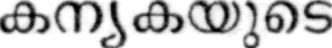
കന്യകയുടെ
